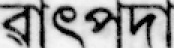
ৱাৎপদা
